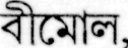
বীমোল,
